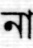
না
